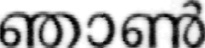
ഞാണ്‍
